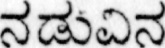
ನಡುವಿನ
